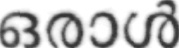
ഒരാള്‍
